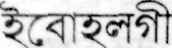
ইবোহলগী
